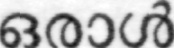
ഒരാള്‍
